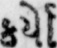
કર્યો
